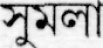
সুমলা
